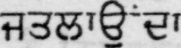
ਜਤਲਾਉਂਦਾ
